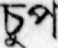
চুপ
